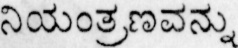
ನಿಯಂತ್ರಣವನ್ನು
